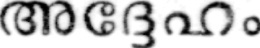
അദ്ദേഹം
